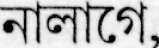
নালাগে,
